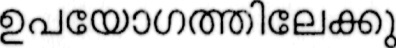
ഉപയോഗത്തിലേക്കു
